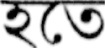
হতে
